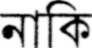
নাকি
